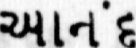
આનંદ
